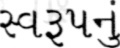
સ્વરૂપનું
